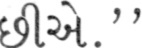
છીએ."
